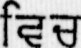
ਵਿਚ
